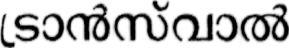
ട്രാന്‍സ്വാല്‍
